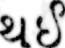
થઈ
